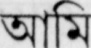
আমি
